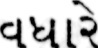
વધારે
